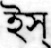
ইস্
